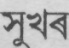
সুখৰ
